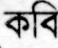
কবি
